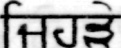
ਜਿਹੜੇ
